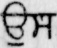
ਉਸ
